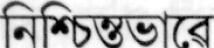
নিশ্চিন্তভাৱে
